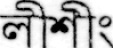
লীশীং
